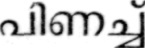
പിണച്ച്
